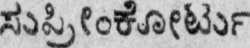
ಸುಪ್ರೀಂಕೋರ್ಟು
